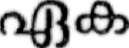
ഏക
